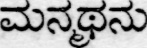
ಮನ್ಮಥನು
